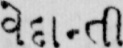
વેદાન્તી
